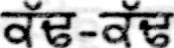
ਕੱਢ-ਕੱਢ
